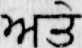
ਅਤੇ
